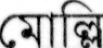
মোল্লি
